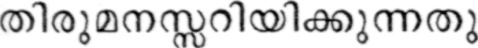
തിരുമനസ്സറിയിക്കുന്നതു
